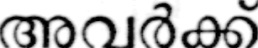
അവര്‍ക്ക്
